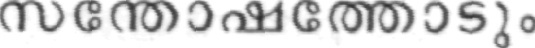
സന്തോഷത്തോടും
